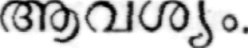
ആവശ്യം.
